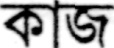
কাজ
